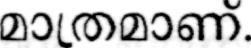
മാത്രമാണ്.
